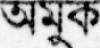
অমুক
